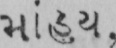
માંહય,
